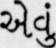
એવું
